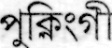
পুক্নিংগী
